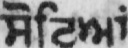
ਸੋਟਿਆਂ
